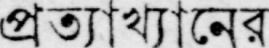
প্রত্যাখ্যানের
